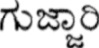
ಗುಜ್ಜಾರಿ
